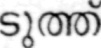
ടുത്ത്
